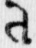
તે
